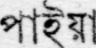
পাইয়া
